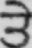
ਤੇ
